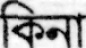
কিনা
